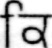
ਕਿ
